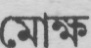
মোক্ষ
